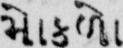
મોકળો
